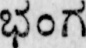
ಭಂಗ
